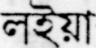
লইয়া
